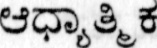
ಆಧ್ಯಾತ್ಮಿಕ
